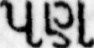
પણ
